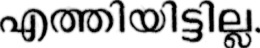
എത്തിയിട്ടില്ല.
